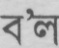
ব'ল
